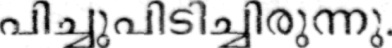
പിച്ചുപിടിച്ചിരുന്നു.
